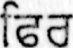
ਫਿਰ
